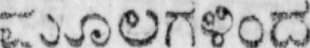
ಮೂಲಗಳಿಂದ
